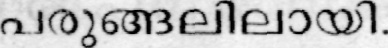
പരുങ്ങലിലായി.
